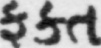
ફક્ત
